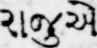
રાજુએ
